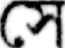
সে
